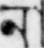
না
